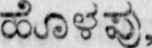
ಹೊಳಪು,
